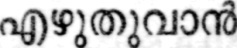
എഴുതുവാന്‍
